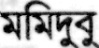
মমিদুবু
